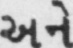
અને
